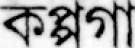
কপ্পগা
